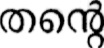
തന്റെ
